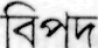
বিপদ
